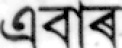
এবাৰ
